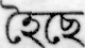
হৈছে
